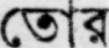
তোর
